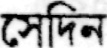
সেদিন
